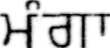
ਮੰਗਾ
